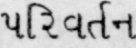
પરિવર્તન
